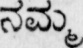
ನಮ್ಮ
